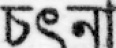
চৎনা
